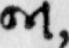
જા,
